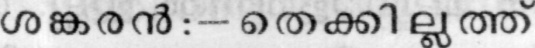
ശങ്കരന്‍:-തെക്കില്ലത്ത്
